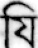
যি
